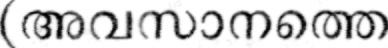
(അവസാനത്തെ
